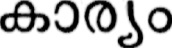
കാര്യം
